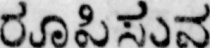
ರೂಪಿಸುವ
